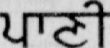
ਪਾਣੀ
